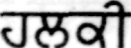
ਹਲਕੀ
